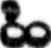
ಹಿ
